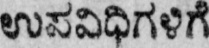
ಉಪವಿಧಿಗಳಿಗೆ
